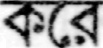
করে
